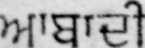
ਆਬਾਦੀ
